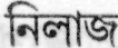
নিলাজ
